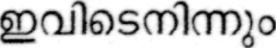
ഇവിടെനിന്നും
